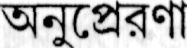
অনুপ্রেরণা
